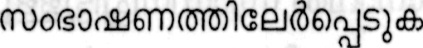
സംഭാഷണത്തിലേര്‍പ്പെടുക
